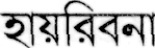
হায়রিবনা
